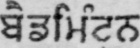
ਬੈਡਮਿੰਟਨ
